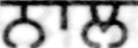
ਨਾਲ
